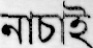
নাচাই
